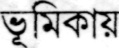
ভূমিকায়
